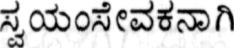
ಸ್ವಯಂಸೇವಕನಾಗಿ
